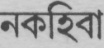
নকহিবা
